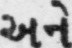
અને
